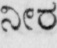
ನೀರ
